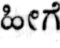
ಹೀಗೆ
